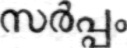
സര്‍പ്പം
